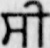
ਸੀ
